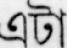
এটা
